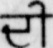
ਦੀ
